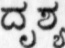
ದೃಶ್ಯ
